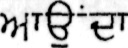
ਆਉਂਦਾ
